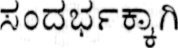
ಸಂದರ್ಭಕ್ಕಾಗಿ
